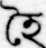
হৈ
